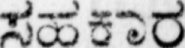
ಸಹಕಾರ
